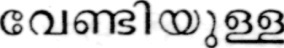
വേണ്ടിയുള്ള
